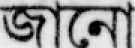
জানো
